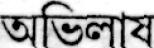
অভিলাষ
